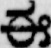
ಈ
